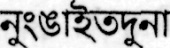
নুংঙাইতদুনা
